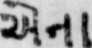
એના
